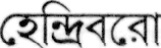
হেন্দ্রিবরো
